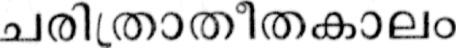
ചരിത്രാതീതകാലം
